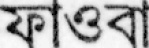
ফাওবা
